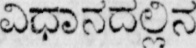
ವಿಧಾನದಲ್ಲಿನ
